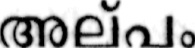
അല്പം
